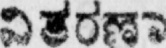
ವಿತರಣಾ
